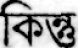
কিন্তু
